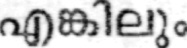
എങ്കിലും
